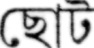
ছোট
